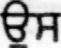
ਉਸ
